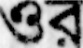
ওর
